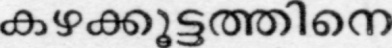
കഴക്കൂട്ടത്തിനെ
